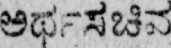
ಅರ್ಥಸಚಿವ
